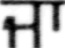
ਜਾ
